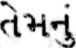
તેમનું
